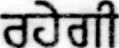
ਰਹੇਗੀ
